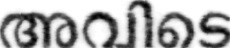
അവിടെ
